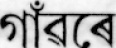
গাঁৱৰে
